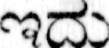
ಇದು
